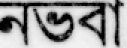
নভবা
